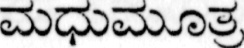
ಮಧುಮೂತ್ರ
